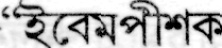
“ইবেমপীশক
